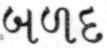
બળદ
